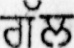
ਗੱਲ
